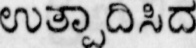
ಉತ್ಪಾದಿಸಿದ
